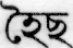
হৈছ
